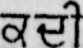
ਕਦੀ
